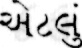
એટલું
